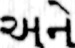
અને
